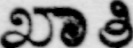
ಖಾತಿ
